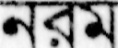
নরম
